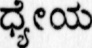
ಧ್ಯೇಯ
